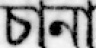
চানা
